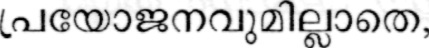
പ്രയോജനവുമില്ലാതെ,
